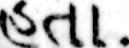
હતા.
